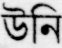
উনি
